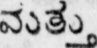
ಮತ್ತು
